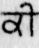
ਕੀ
